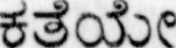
ಕತೆಯೇ
